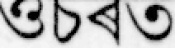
ওচৰত
